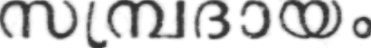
സമ്പ്രദായം
